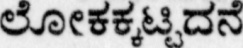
ಲೋಕಕ್ಕಟ್ಟಿದನೆ
